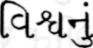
વિશ્વનું
